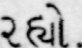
રહ્યો.
